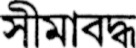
সীমাবদ্ধ
